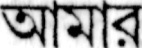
আমার
